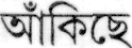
আঁকিছে
